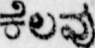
ಕೆಲವು
